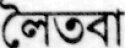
লৈতবা
